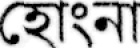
হোংনা
